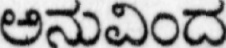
ಅನುವಿಂದ
